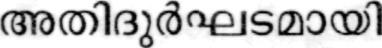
അതിദുര്‍ഘടമായി
